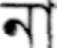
না
